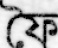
ফৈ
